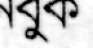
নবুক
